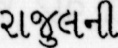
રાજુલની
